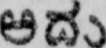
ಅದು
